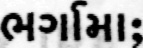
ભર્ગામા;
